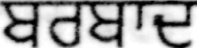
ਬਰਬਾਦ
